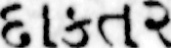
દાકતર
